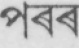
পৰৰ
